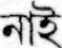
নাই
